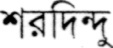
শরদিন্দু
